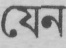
যেন
